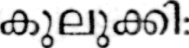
കുലുക്കി:
